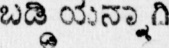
ಬಡ್ದಿಯನ್ನಾಗಿ
